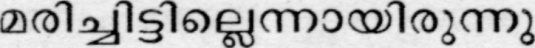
മരിച്ചിട്ടില്ലെന്നായിരുന്നു
